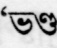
‘ভণ্ড
